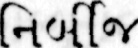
નિર્બીજ
